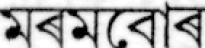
মৰমবোৰ
